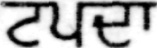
ਟਪਦਾ
